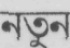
নতুন
